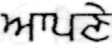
ਆਪਣੇ
